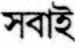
সবাই
